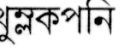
খুম্লকপনি
